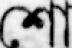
শো
